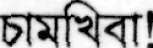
চামখিবা!
